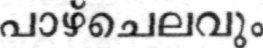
പാഴ്ചെലവും
